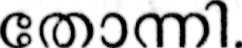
തോന്നി.
